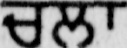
ਚਲਾ
